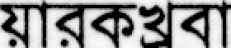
য়ারকখ্রবা
